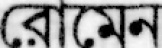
রোমেন
